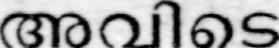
അവിടെ
